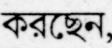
করছেন,
